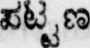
ಪಟ್ಟಣ
